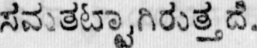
ಸಮತಟ್ಟಾಗಿರುತ್ತದೆ.
